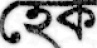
হেক
